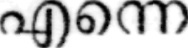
എന്നെ
